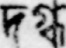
দগ্ধ
